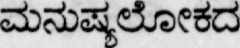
ಮನುಷ್ಯಲೋಕದ
